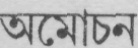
অমোচন
